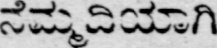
ನೆಮ್ಮದಿಯಾಗಿ
